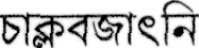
চাক্লবজাৎনি
